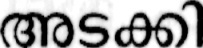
അടക്കി
